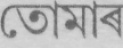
তোমাৰ
